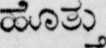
ಹೊತ್ತು
